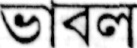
ভাবল
